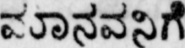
ಮಾನವನಿಗೆ
